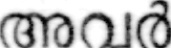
അവര്‍
